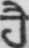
ਹੈ
